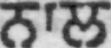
ਨਾਲ
